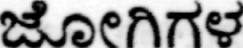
ಜೋಗಿಗಳ
